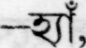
-হ্যাঁ,
